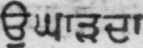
ਉਘਾੜਦਾ
